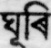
ঘূৰি
